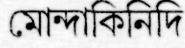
মোন্দাকিনিদি
